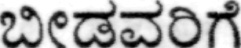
ಬೀಡವರಿಗೆ
